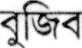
বুজিব
